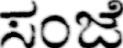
ಸಂಜೆ
